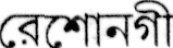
রেশোনগী
